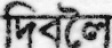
দিবলৈ
